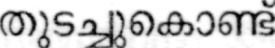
തുടച്ചുകൊണ്ട്
